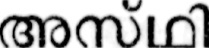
അസ്ഥി
